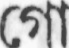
গো
